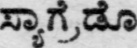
ಸ್ಯಾಗ್ರೆಡೊ
